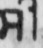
ਸੀ
